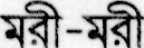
মরী-মরী
